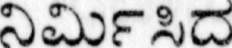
ನಿರ್ಮಿಸಿದ
